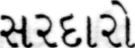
સરદારો
